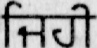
ਜਿਹੀ
